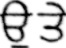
ਉਤੇ
